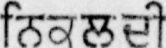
ਨਿਕਲਦੀ
